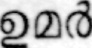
ഉമര്‍
